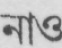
নাও
